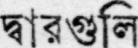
দ্বারগুলি
